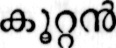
കൂറ്റന്‍
